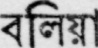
বলিয়া
